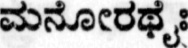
ಮನೋರಥೈಃ
